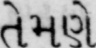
તેમણે
